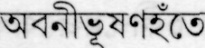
অবনীভূষণহঁতে
